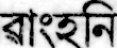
ৱাংহনি
